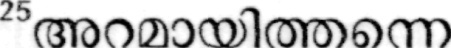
25അറമായിത്തന്നെ
